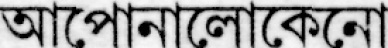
আপোনালোকেনো
